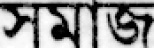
সমাজ
